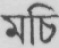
মচি
